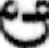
ಆ
